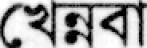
খেন্নবা
